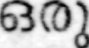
ഒരു
